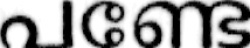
പണ്ടേ
